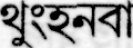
থুংহনবা
